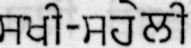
ਸਖੀ-ਸਹੇਲੀ
